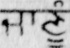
ਜਾਣੂੰ
